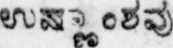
ಉಷ್ಣಾಂಶವು
